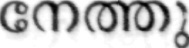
നേത്തു
